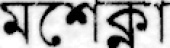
মশেক্না
